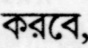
করবে,
